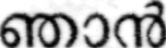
ഞാന്‍
